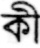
কী
